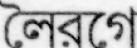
লৈরগে
